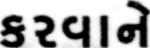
કરવાને
